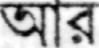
আর
